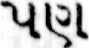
પણ
